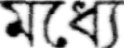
মধ্যে
